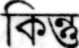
কিন্তু
